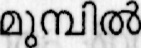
മുമ്പില്‍
